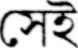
সেই
